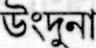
উংদুনা
